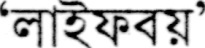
‘লাইফবয়’
